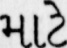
માટે
